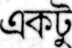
একটু
